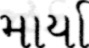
માર્યા
